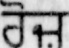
ਰੋਜ਼
